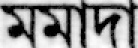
মমাদা
